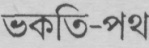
ভকতি-পথ
